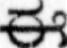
ಈ
